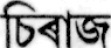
চিৰাজ
